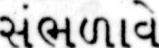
સંભળાવે
